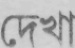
দেখা
